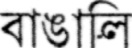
বাঙালি
